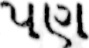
પણ
